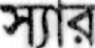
স্যার
